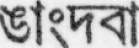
ঙাংদবা
